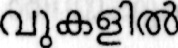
വുകളില്‍
